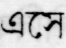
এসে
